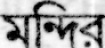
মন্দির
